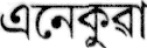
এনেকুৱা
